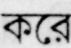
করে
